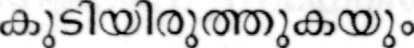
കുടിയിരുത്തുകയും
